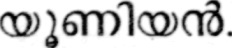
യൂണിയന്‍.
